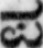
ಪ
